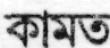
কামত
